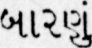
બારણું
